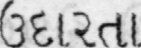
ઉદારતા
